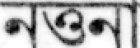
নত্তনা
